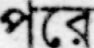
পরে
